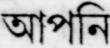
আপনি
